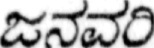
ಜನವರಿ
